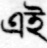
এই
